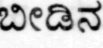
ಬೀಡಿನ
